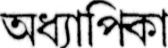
অধ্যাপিকা
